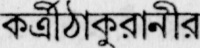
কর্ত্রীঠাকুরানীর
